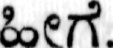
ಹೀಗೆ.
